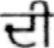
ਦੀ
